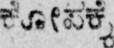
ಕೋಪಕ್ಕೆ
